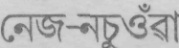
নেজ-নচুওঁৱা
